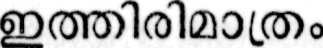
ഇത്തിരിമാത്രം
